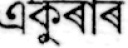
একুৰাৰ
